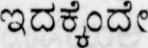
ಇದಕ್ಕೆಂದೇ
